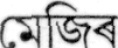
মেজিৰ
